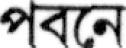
পবনে
